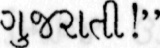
ગુજરાતી!"
